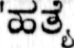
‘ಹತ್ಯೆ
